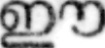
ഈ
